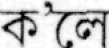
ক'লে
